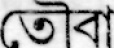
তৌবা
